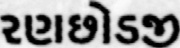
રણછોડજી
